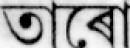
তাৰো
